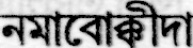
নমাবোক্কীদা
